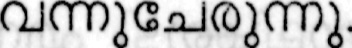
വന്നുചേരുന്നു.
